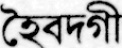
হৈবদগী
